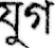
যুগ
